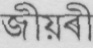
জীয়ৰী
